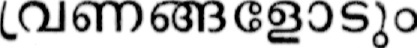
വ്രണങ്ങളോടും
